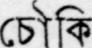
চৌকি
